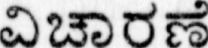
ವಿಚಾರಣೆ
